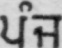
ਪੰਜ
